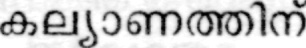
കല്യാണത്തിന്
